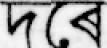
দৰে
